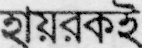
হায়রকই
